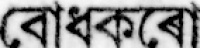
বোধকৰো
